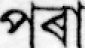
পৰা
